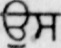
ਉਸ
